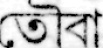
তৌবা
